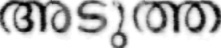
അടുത്ത
